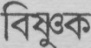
বিষ্ণুক
